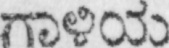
ಗಾಳಿಯ
